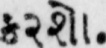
કરશો.
